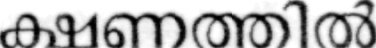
ക്ഷണത്തില്‍
